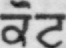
ਕੋਟ
